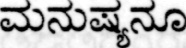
ಮನುಷ್ಯನೂ
